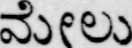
ಮೇಲು
